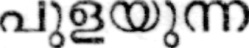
പുളയുന്ന
